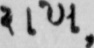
રાખ,
